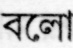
বলো
